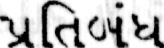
પ્રતિબંધ
